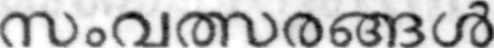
സംവത്സരങ്ങള്‍
